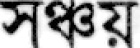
সঞ্চয়
